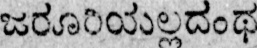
ಜರೂರಿಯಲ್ಲದಂಥ
